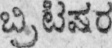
ಬ್ರಿಟಿಷರ
